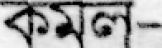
কমল-
